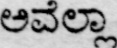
ಅವೆಲ್ಲಾ
